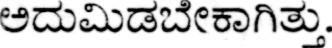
ಅದುಮಿಡಬೇಕಾಗಿತ್ತು.
